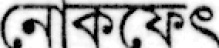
নোকফেৎ
